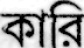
কারি
